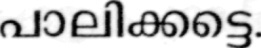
പാലിക്കട്ടെ.
